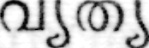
വ്യത്യ
